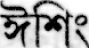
ঈশিং
